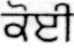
ਕੋਈ
